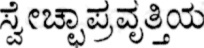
ಸ್ವೇಚ್ಛಾಪ್ರವೃತ್ತಿಯ
